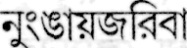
নুংঙায়জরিবা
